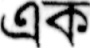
এক
